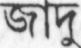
জাদু
